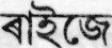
ৰাইজে
